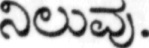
ನಿಲುವು.
